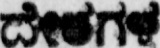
ದೇಶಗಳ
